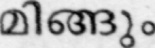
മിങ്ങും
